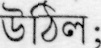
উঠিল;
